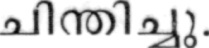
ചിന്തിച്ചു.
